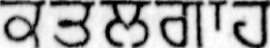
ਕਤਲਗਾਹ
